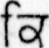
ਕਿ
